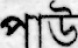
পাউ
